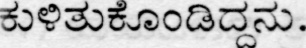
ಕುಳಿತುಕೊಂಡಿದ್ದನು.
